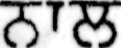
ਨਾਲ
